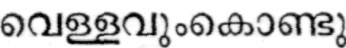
വെള്ളവുംകൊണ്ടു
